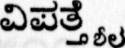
ವಿಪತ್ತ್ಯೈ
